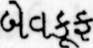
બેવકૂફ
